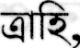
ত্রাহি,
